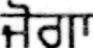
ਜੋਗਾ
